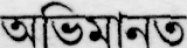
অভিমানত
